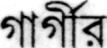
গার্গীর
